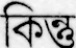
কিন্তু
